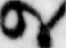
જ
